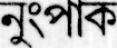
নুংপাক
